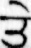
ਤੇ
